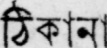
ঠিকানা
